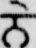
ਨੇ
